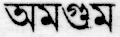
অমগুম
